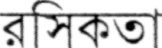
রসিকতা
